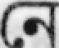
নে
